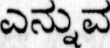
ಎನ್ನುವ
